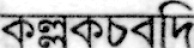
কল্লকচবদি
